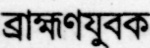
ব্রাহ্মণযুবক
